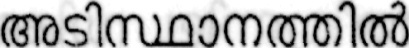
അടിസ്ഥാനത്തില്‍
